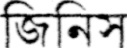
জিনিস
